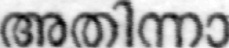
അതിന്നാ
